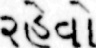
રહેવો
